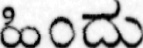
ಹಿಂದು
